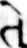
તે
